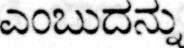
ಎಂಬುದನ್ನು
